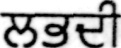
ਲਭਦੀ
